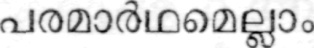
പരമാര്‍ഥമെല്ലാം
